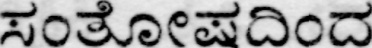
ಸಂತೋಷದಿಂದ
